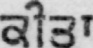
ਕੀਤਾ
